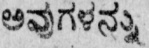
ಅವುಗಳನ್ನು
